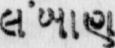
લંબાણ
